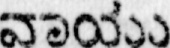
ವಾಯು
